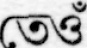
তেওঁ
